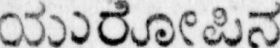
ಯುರೋಪಿನ
